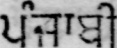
ਪੰਜਾਬੀ
